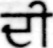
ਦੀ
